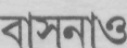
বাসনাও
